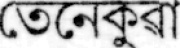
তেনেকুৱা
